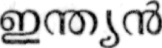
ഇന്ത്യന്‍
